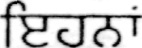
ਇਹਨਾਂ
